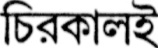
চিরকালই
